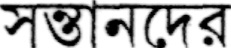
সন্তানদের
